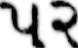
પર
